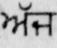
ਅੱਜ
